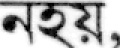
নহয়,
